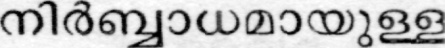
നിര്‍ബ്ബാധമായുള്ള
